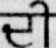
ਦੀ
